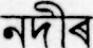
নদীৰ
